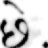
છે.
